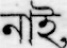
নাই,
